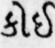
કોઈ
